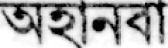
অহানবা
